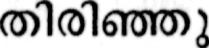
തിരിഞ്ഞു
